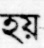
হয়
